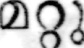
മറ്റു
